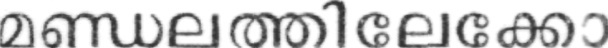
മണ്ഡലത്തിലേക്കോ
